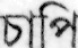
চাপি
